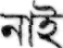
নাই
